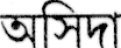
অসিদা
